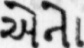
એનો
